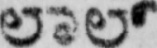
ಲಾಲ್
